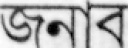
জনাব
